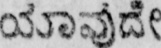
ಯಾವುದೇ
